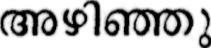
അഴിഞ്ഞു
